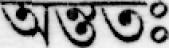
অন্ততঃ
